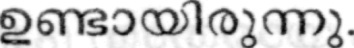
ഉണ്ടായിരുന്നു.
